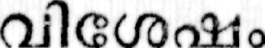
വിശേഷം
